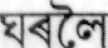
ঘৰলৈ
